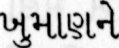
ખુમાણને
